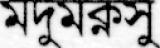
মদুমক্নসু
